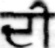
ਦੀ
